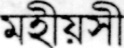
মহীয়সী
